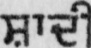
ਸ਼ਾਦੀ
